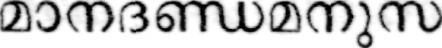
മാനദണ്ഡമനുസ
